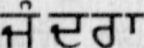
ਜੰਦਰਾ
